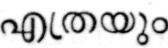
എത്രയും
